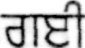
ਗਈ
